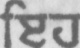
ਇਹ
